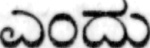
ಎಂದು
